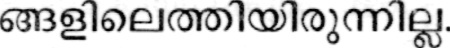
ങ്ങളിലെത്തിയിരുന്നില്ല.
